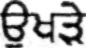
ਉਖੜੇ
